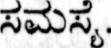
ಸಮಸ್ಯೆ.
